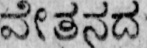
ವೇತನದ
